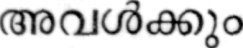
അവള്‍ക്കും
